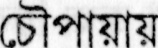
চৌপায়ায়
